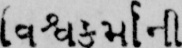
વિશ્વકર્માની
